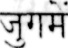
जुगमें
